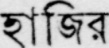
হাজির
